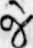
જે
